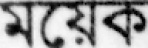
ময়েক
